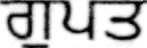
ਗੁਪਤ
